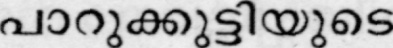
പാറുക്കുട്ടിയുടെ
